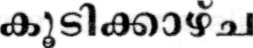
കൂടിക്കാഴ്ച
